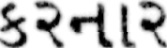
કરનાર
